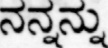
ನನ್ನನ್ನು
